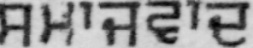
ਸਮਾਜਵਾਦ
